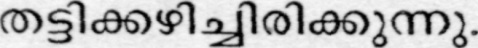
തട്ടിക്കഴിച്ചിരിക്കുന്നു.
